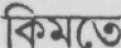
কিমতে
